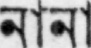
নানা
